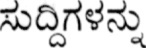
ಸುದ್ದಿಗಳನ್ನು
